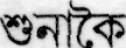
শুনাকৈ
